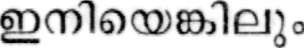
ഇനിയെങ്കിലും
